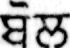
ਬੋਲ
